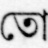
তো
